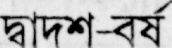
দ্বাদশ-বর্ষ
